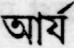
আর্য
